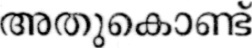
അതുകൊണ്ട്
